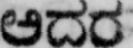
ಅದರ
